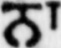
ਨਾ
